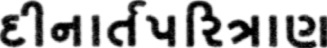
દીનાર્તપરિત્રાણ
